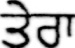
ਤੇਰਾ
